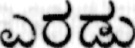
ಎರಡು
